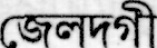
জেলদগী
